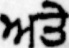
ਅਤੇ
